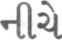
નીચે
